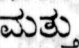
ಮತ್ತು
